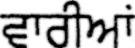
ਵਾਰੀਆਂ
